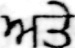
ਅਤੇ
